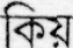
কিয়
